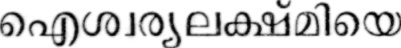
ഐശ്വര്യലക്ഷ്മിയെ
